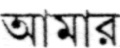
আমার
